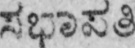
ಸಭಾಪತಿ
